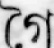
গৈ
